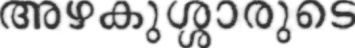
അഴകുശ്ശാരുടെ
